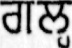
ਗਲ੍ਹ
